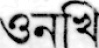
ওনখি
